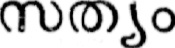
സത്യം
